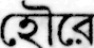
হৌরে
